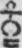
ਨੂੰ
